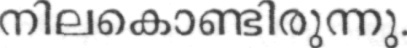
നിലകൊണ്ടിരുന്നു.
